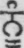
ਨੂੰ
